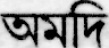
অমদি
